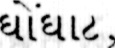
ઘોંઘાટ,
